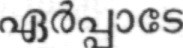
ഏര്‍പ്പാടേ
